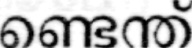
ണ്ടെന്ത്
